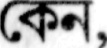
কেন,
